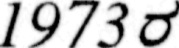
1973ರ
